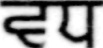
ਵਧ
